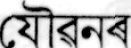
যৌৱনৰ
